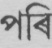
পৰি
